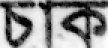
চাক
